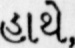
હાથે,
